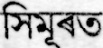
সিমূৰত
